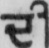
ਦੀ
